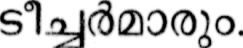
ടീച്ചര്‍മാരും.
